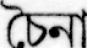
চৈনা
